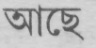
আছে
